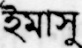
ইমাসু
